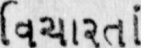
વિચારતાં
